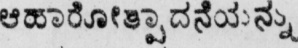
ಆಹಾರೋತ್ಪಾದನೆಯನ್ನು
